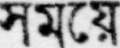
সময়ে
